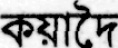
কয়াদৈ
